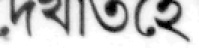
দেখাতহে
